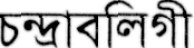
চন্দ্রাবলিগী
